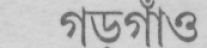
গড়গাঁও
